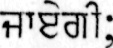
ਜਾਏਗੀ;
